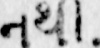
નથી.
